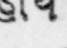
હોય
